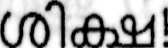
ശിക്ഷ!
